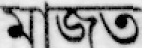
মাজত
